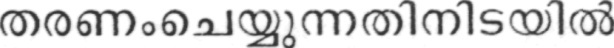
തരണംചെയ്യുന്നതിനിടയില്‍
